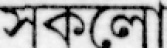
সকলো
